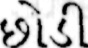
છોડી
